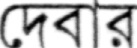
দেবার
